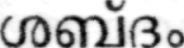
ശബ്ദം
